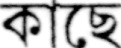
কাছে
